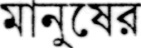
মানুষের
